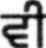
ਵੀ
